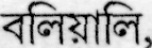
বলিয়ালি,
